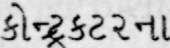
કોન્ટ્રકટરના
